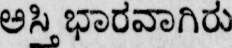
ಅಸ್ತಿಭಾರವಾಗಿರು
